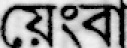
য়েংবা
